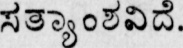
ಸತ್ಯಾಂಶವಿದೆ.
